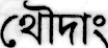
থৌদাং
